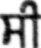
ਸੀ
